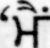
'ਮੈਂ
